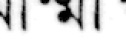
মাম্মা
